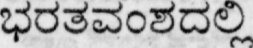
ಭರತವಂಶದಲ್ಲಿ
